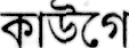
কাউগে
